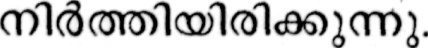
നിര്‍ത്തിയിരിക്കുന്നു.
